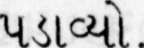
પડાવ્યો.
